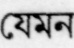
যেমন
